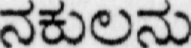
ನಕುಲನು
